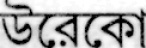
উরেকো
